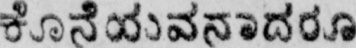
ಕೊನೆಯವನಾದರೂ
